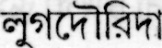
লুগদৌরিদা
